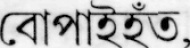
বোপাইহঁত,
